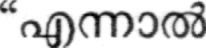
“എന്നാല്‍
